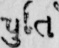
પુર્તિ
